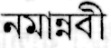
নমান্নবী
